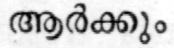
ആര്‍ക്കും
